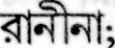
রানীনা;
